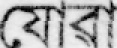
যোৱা
